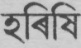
হৰিষি
